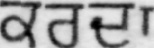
ਕਰਦਾ
